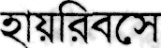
হায়রিবসে
